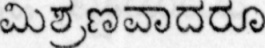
ಮಿಶ್ರಣವಾದರೂ
